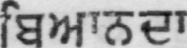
ਬਿਆਨਦਾ
